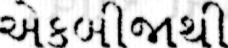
એકબીજાથી
